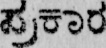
ಪ್ರಕಾರ
